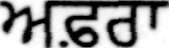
ਅਫ਼ਰਾ
